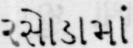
રસોડામાં
